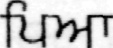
ਪਿਆ
